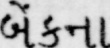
બેંકના
